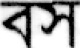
বস
